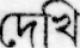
দেখি
